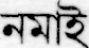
নমাই
